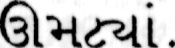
ઊમટ્યાં.
